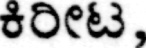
ಕಿರೀಟ,
